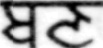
ਬਣ
